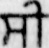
ਸੀ
